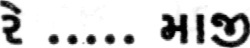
રે.......માજી
